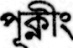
পূক্নীং
